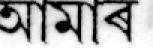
আমাৰ
